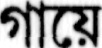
গায়ে
